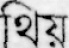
থিয়
